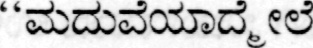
"ಮದುವೆಯಾದ್ಮೇಲೆ
